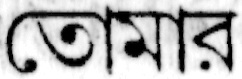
তোমার
